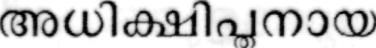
അധിക്ഷിപ്തനായ
